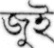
জুই
